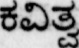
ಕವಿತ್ವ
